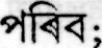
পৰিব;
